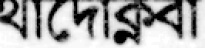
থাদোক্নবা
